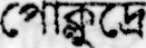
পোক্লুদ্রে
